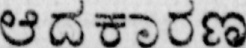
ಆದಕಾರಣ
